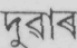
দুৱাৰ
